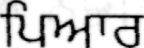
ਪਿਆਰ
